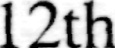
12th
